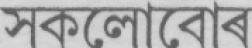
সকলোবোৰ
